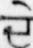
ਦੇ
